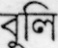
বুলি
